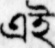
এই
